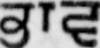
ਭਾਵ
